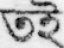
তই
